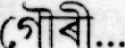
গৌৰী...
